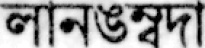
লানঙম্বদা
